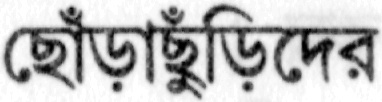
ছোঁড়াছুঁড়িদের
